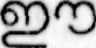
ഈ
